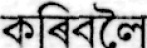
কৰিবলৈ
